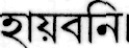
হায়বনি।
